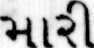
મારી
